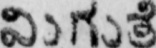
ಮಿಗುತೆ
